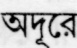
অদূরে
